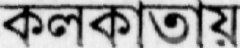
কলকাতায়
